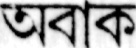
অবাক
